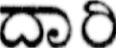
ದಾರಿ
